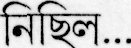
নিছিল...
